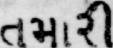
તમારી
